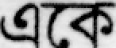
একে
